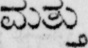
ಮತ್ತು
